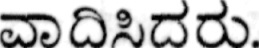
ವಾದಿಸಿದರು.
